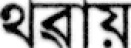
থৱায়
